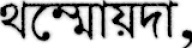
থম্মোয়দা,
